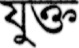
যুক্ত
